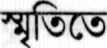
স্মৃতিতে
